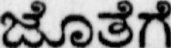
ಜೊತೆಗೆ
